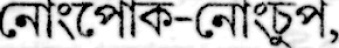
নোংপোক-নোংচুপ,
